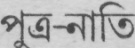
পুত্ৰ-নাতি
